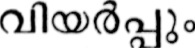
വിയര്‍പ്പും
